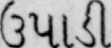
ઉપાડી
